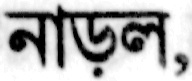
নাড়ল,
